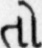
તો
